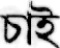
চাই
